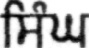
ਸਿੰਘ
